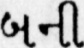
બની
